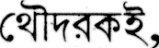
থৌরকই,
